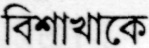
বিশাখাকে
